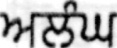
ਅਲੰਘ
